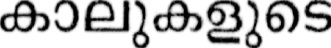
കാലുകളുടെ
